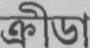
ক্ৰীড়া
